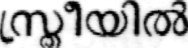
സ്ത്രീയില്‍
